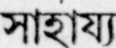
সাহায্য
